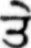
ਤੇ
